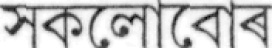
সকলোবোৰ
